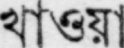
খাওয়া
